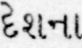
દેશના
